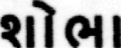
શોભા
